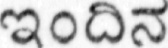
ಇಂದಿನ
